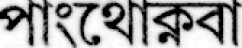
পাংথোক্নবা
